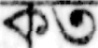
কত
